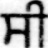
ਸੀ
